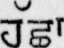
ਹੱਛਾ
